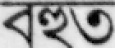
বহুত
